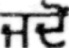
ਜਦੋਂ
